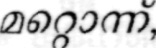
മറ്റൊന്ന്,
